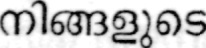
നിങ്ങളുടെ
